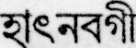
হাৎনবগী
